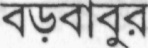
বড়বাবুর
